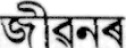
জীৱনৰ
